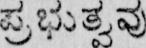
ಪ್ರಭುತ್ವವು
